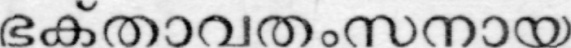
ഭക്താവതംസനായ
